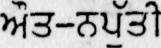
ਔਤ-ਨਪੁੱਤੀ
